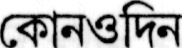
কোনওদিন
